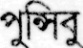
পুন্সিবু
